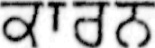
ਕਾਰਨ
